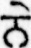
ਨੇ
